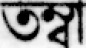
তম্বা
